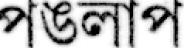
পঙলাপ
